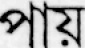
পায়
